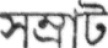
সম্রাট
